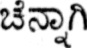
ಚೆನ್ನಾಗಿ
